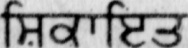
ਸ਼ਿਕਾਇਤ
